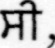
ਸੀ,
